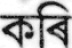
কৰি
